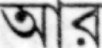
আর
